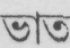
ভাত
